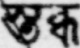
স্তব্ধ
